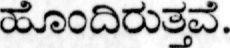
ಹೊಂದಿರುತ್ತವೆ.
